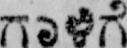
ಗಾಳಿಗೆ
